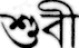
শুবী
